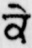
ਕੇ
